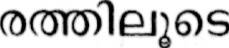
രത്തിലൂടെ
